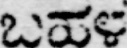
ಬಹಳ
